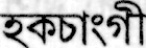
হকচাংগী
